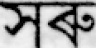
সৰু
